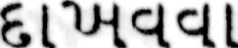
દાખવવા
